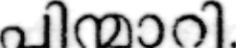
പിന്മാറി.
